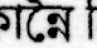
কান্নৈ
